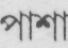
পাশা
